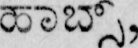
ಹಾಬ್ಸ್,
